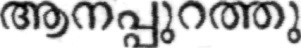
ആനപ്പുറത്തു
